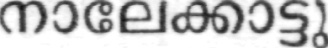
നാലേക്കാട്ടു
